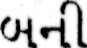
બની
